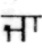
ਜਾ
